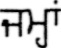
ਜਮ੍ਹਾਂ
